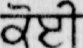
ਕੋਈ
